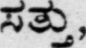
ಸತ್ತು,
